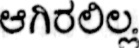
ಆಗಿರಲಿಲ್ಲ.
